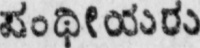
ಪಂಥೀಯರು
